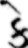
કે
